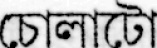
চোলাটো
